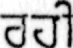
ਰਹੀ
